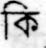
কি
